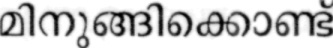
മിനുങ്ങിക്കൊണ്ട്
